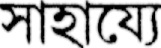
সাহায্যে
